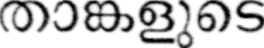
താങ്കളുടെ
